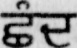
ਛੰਦ
